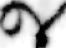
જ
